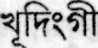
খূদিংগী
